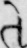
તે
